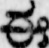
ಈ
